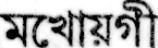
মখোয়গী
